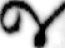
જ
